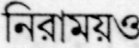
নিরাময়ও
